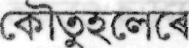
কৌতুহলেৰে
